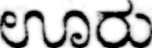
ಊರು
